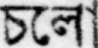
চলো
